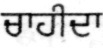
ਚਾਹੀਦਾ
